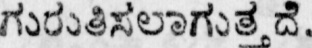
ಗುರುತಿಸಲಾಗುತ್ತದೆ.
